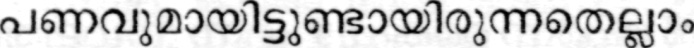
പണവുമായിട്ടുണ്ടായിരുന്നതെല്ലാം
